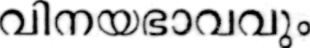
വിനയഭാവവും
